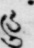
હું
